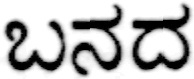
ಬನದ
